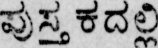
ಪುಸ್ತಕದಲ್ಲಿ
